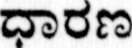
ಧಾರಣ
